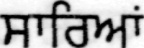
ਸਾਰਿਆਂ
